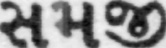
સમજી
